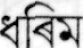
ধৰিম
